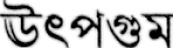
ঊৎপগুম
